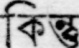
কিন্তু
